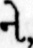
ને,
